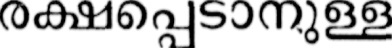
രക്ഷപ്പെടാനുള്ള
